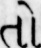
તો
